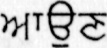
ਆਉਣ
